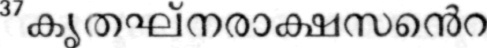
37കൃതഘ്നരാക്ഷസൻെറ
